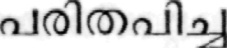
പരിതപിച്ച
